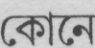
কোনে
